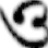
ও
